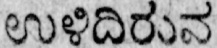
ಉಳಿದಿರುವ
